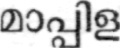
മാപ്പിള
